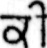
ਕੀ
